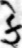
કે
